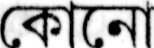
কোনো
